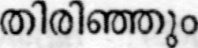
തിരിഞ്ഞും
